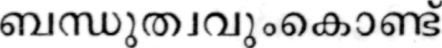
ബന്ധുത്വവുംകൊണ്ട്
